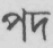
পদ
